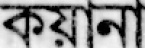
কয়ানা
